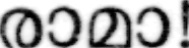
രാമാ!
